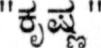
“ಕೃಷ್ಣ”
